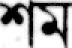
শম
